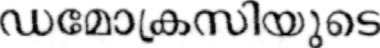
ഡമോക്രസിയുടെ
